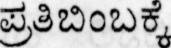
ಪ್ರತಿಬಿಂಬಕ್ಕೆ
